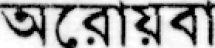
অরোয়বা
